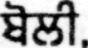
ਬੋਲੀ,
